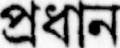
প্রধান
